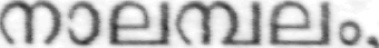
നാലമ്പലം,
